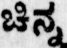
ಚಿನ್ನ
